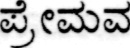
ಪ್ರೇಮವ
